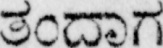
ತಂದಾಗ
